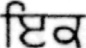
ਇਕ
